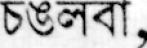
চঙলবা,
